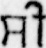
ਸੀ
